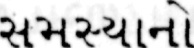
સમસ્યાનો
